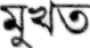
মুখত
